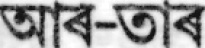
আৰ-তাৰ
